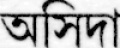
অসিদা
